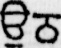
ਉਠ
